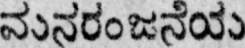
ಮನರಂಜನೆಯ
